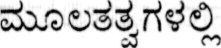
ಮೂಲತತ್ವಗಳಲ್ಲಿ
